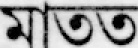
মাতত
